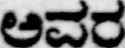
ಅವರ
